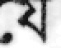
যে
